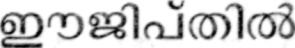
ഈജിപ്തില്‍
